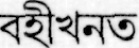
বহীখনত
